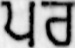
ਪਰ
